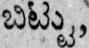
ಬಿಟ್ಟು,
